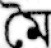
মৈ
